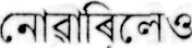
নোৱাৰিলেও
